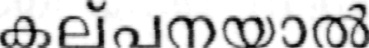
കല്പനയാല്‍
